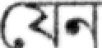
যেন
